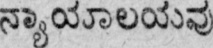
ನ್ಯಾಯಾಲಯವು
